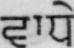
ਵਾਧੇ
